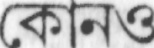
কোনও
